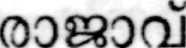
രാജാവ്
